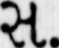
સ.
